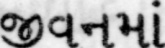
જીવનમાં
